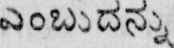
ಎಂಬುದನ್ನು
